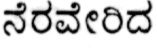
ನೆರವೇರಿದ
